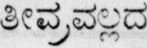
ತೀವ್ರವಲ್ಲದ
